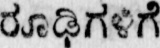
ರೂಢಿಗಳಿಗೆ
